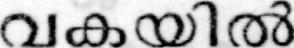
വകയില്‍
